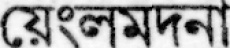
য়েংলমদনা
